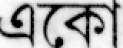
একো
